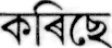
কৰিছে
